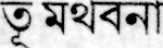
তূমথবনা
